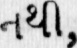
નથી,
